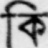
কি
